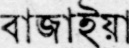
বাজাইয়া
